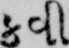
કેવી
